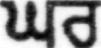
ਘਰ
